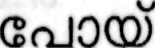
പോയ്
